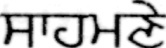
ਸਾਹਮਣੇ
